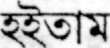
হইতাম
